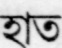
হাত
